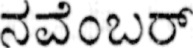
ನವೆಂಬರ್
